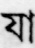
যা
